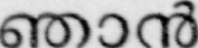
ഞാന്‍
